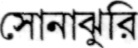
সোনাঝুরি
